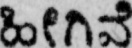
ಹೀಗಿವೆ
